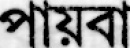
পায়বা
